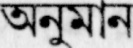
অনুমান
